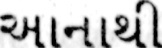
આનાથી
